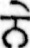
ਨੇ
